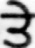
ਤੇ
